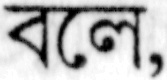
বলে,
